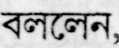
বললেন,
